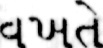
વખતે
